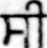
ਸੀ
